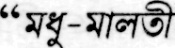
“মধু-মালতী
